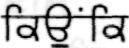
ਕਿਉਂਕਿ
